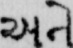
અને
